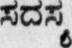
ಸದಸ್ಯ
